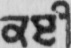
ਕਈ
